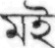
মই
